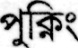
পুক্নিং
